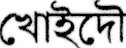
খোইদৌ
